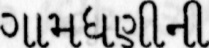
ગામધણીની
